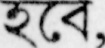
হবে,
